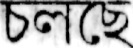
চলছে
